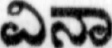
ವಿನಾ
